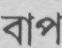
বাপ
